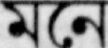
মনে
